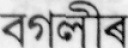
বগলীৰ
